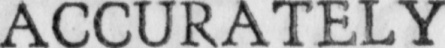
ACCURATELY
